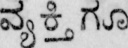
ವ್ಯಕ್ತಿಗೂ
